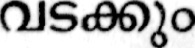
വടക്കും
